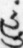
હું
